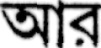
আর
